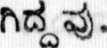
ಗಿದ್ದವು.
